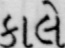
કાલે
